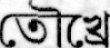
তৌখ্রে
